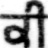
ਕੀ
